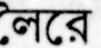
লৈরে
